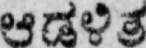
ಆಡಳಿತ
